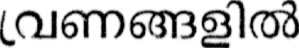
വ്രണങ്ങളില്‍
